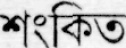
শংকিত
